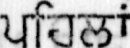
ਪਹਿਲਾਂ
